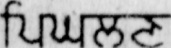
ਪਿਘਲਣ
